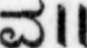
ವ||
